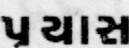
પ્રયાસ
